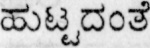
ಹುಟ್ಟದಂತೆ
